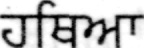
ਹਥਿਆ
